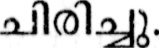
ചിരിച്ചു.
